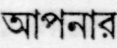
আপনার
